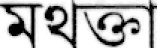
মথক্তা
